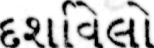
દર્શાવેલો
